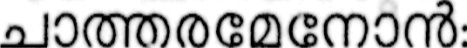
ചാത്തരമേനോന്‍:
